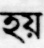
হয়
